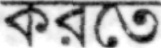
করতে
